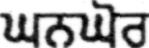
ਘਨਘੋਰ
